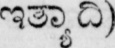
ಇತ್ಯಾದಿ)
